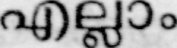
എല്ലാം
